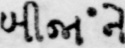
કે
